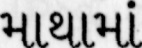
માથામાં
